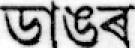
ডাঙৰ
